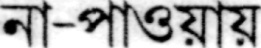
না-পাওয়ায়
